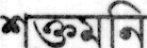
শক্তমনি
